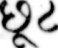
છૂટ
